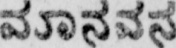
ಮಾನವನ
